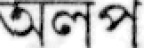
অলপ
